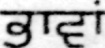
ਭਾਵਾਂ
